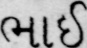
ભાઈ
